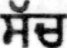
ਸੱਚ
